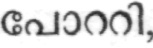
പോററി,
